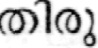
തിരു
